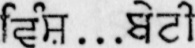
ਵਿੰਸ਼......ਬੇਟੀ
